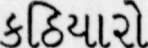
કઠિયારો
